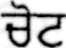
ਚੋਟ
